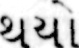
થયો
